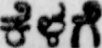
ಕೆಳಗೆ
